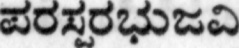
ಪರಸ್ಪರಭುಜವಿ
